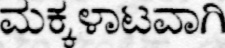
ಮಕ್ಕಳಾಟವಾಗಿ
